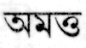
অমত্ত
